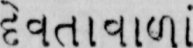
દેવતાવાળાં
